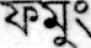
ফমুং
